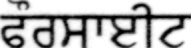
ਫੌਰਸਾਈਟ
